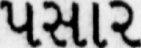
પસાર
